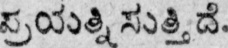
ಪ್ರಯತ್ನಿಸುತ್ತಿದೆ.
